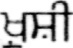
ਖ਼ੁਸ਼ੀ
